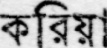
করিয়া
